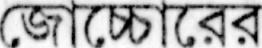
জোচ্চোরের
